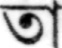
তা
